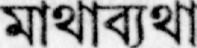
মাথাব্যথা
